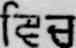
ਵਿਚ
